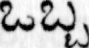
ಒಬ್ಬ
